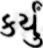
કર્યું
